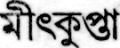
মীৎকুপ্তা
